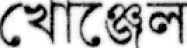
খোঞ্জেল
